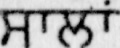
ਸਾਲਾਂ
